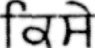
ਕਿਸੇ
